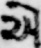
એ
